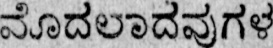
ಮೊದಲಾದವುಗಳ
